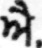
ਐ,
